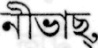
নীভাছ্,
